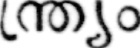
ന്ത്ര്യം
